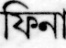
ফিনা
